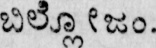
ಬಿಲ್ಲೋಜಂ.
